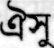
ঐসু
